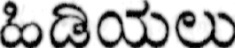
ಹಿಡಿಯಲು
